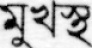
মুখস্থ
